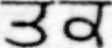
ਤਕ
